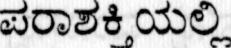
ಪರಾಶಕ್ತಿಯಲ್ಲಿ
